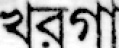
খরগা
